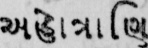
અહોત્રાણિ
